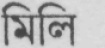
মিলি
